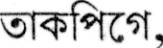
তাকপিগে,
